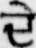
ਦੇ
